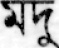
মদু
